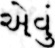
એવું
